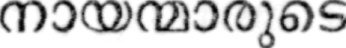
നായന്മാരുടെ
